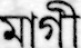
মাগী
